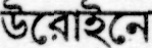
উরোইনে
